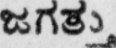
ಜಗತ್ತು
